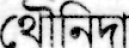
থৌনিদা
